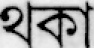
থকা
